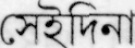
সেইদিনা
